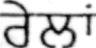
ਰੇਲਾਂ
